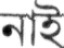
নাই
